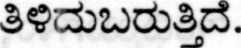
ತಿಳಿದುಬರುತ್ತಿದೆ.
